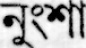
নুংশা
